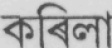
কৰিলা
